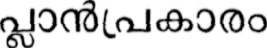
പ്ലാന്‍പ്രകാരം
